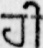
ਹੀ
